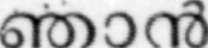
ഞാന്‍
